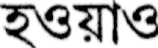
হওয়াও
